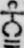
ਨੂੰ
